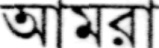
আমরা
